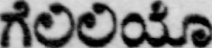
ಗೆಲಿಲಿಯೊ
